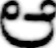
ಆ
